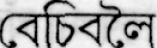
বেচিবলৈ
